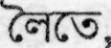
লৈতে,
